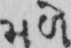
મળે
